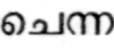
ചെന്ന
